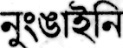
নুংঙাইনি
